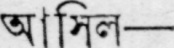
আসিল—
